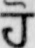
ਹੋ
